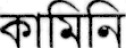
কামিনি
